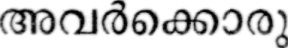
അവര്‍ക്കൊരു
